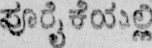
ಪೂರೈಕೆಯಲ್ಲಿ
